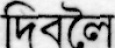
দিবলৈ
